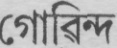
গোৱিন্দ
